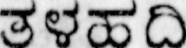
ತಳಹದಿ
